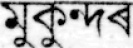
মুকুন্দৰ
